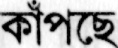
কাঁপছে
